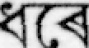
ধৰে
